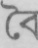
বৈ
